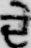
ਦੇ
